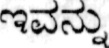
ಇವನ್ನು
